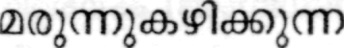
മരുന്നുകഴിക്കുന്ന
